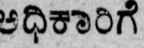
ಅಧಿಕಾರಿಗೆ
